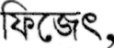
ফিজেৎ,
